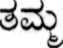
ತಮ್ಮ
